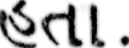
હતા.
